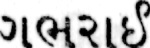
ગભરાઈ
